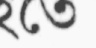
হতে
